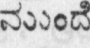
ಮುಂದೆ
